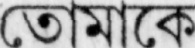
তোমাকে
